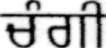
ਚੰਗੀ
